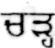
ਚੜ੍ਹ
